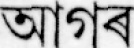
আগৰ
